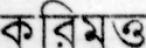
করিমত্ত
